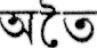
অতৈ
